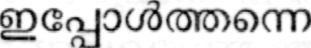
ഇപ്പോള്‍ത്തന്നെ
